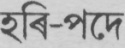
হৰি-পদে
